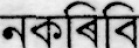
নকৰিবি
